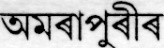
অমৰাপুৰীৰ
